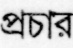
প্রচার
